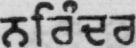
ਨਰਿੰਦਰ
